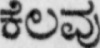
ಕೆಲವು
